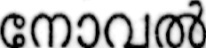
നോവല്‍
